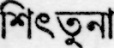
শিৎতুনা
